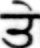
ਤੇ
